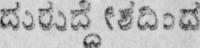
ದುರುದ್ದೇಶದಿಂದ
